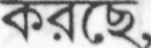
করছে,
